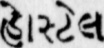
હોસ્ટેલ
